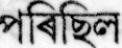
পৰিছিল
